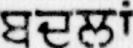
ਬਦਲਾਂ
